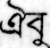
ঐবু
